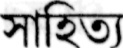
সাহিত্য
